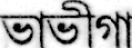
ভাভীগা
